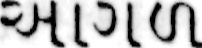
આગળ
